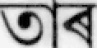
তাৰ
